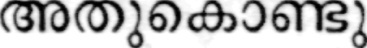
അതുകൊണ്ടു
